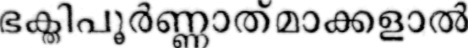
ഭക്തിപൂര്‍ണ്ണാത്മാക്കളാല്‍
